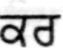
ਕਰ
